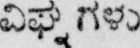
ವಿಘ್ನಗಳು
